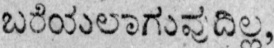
ಬರೆಯಲಾಗುವುದಿಲ್ಲ,
